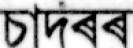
চাদৰৰ
